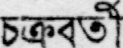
চক্রবর্তী
